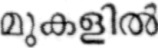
മുകളില്‍
